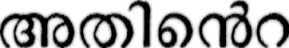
അതിന്റെ
